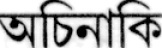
অচিনাকি
